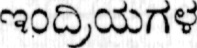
ಇಂದ್ರಿಯಗಳ
